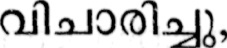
വിചാരിച്ചു,
